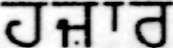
ਹਜ਼ਾਰ
